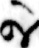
જે
